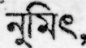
নুমিৎ,
